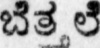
ಬೆತ್ತಲೆ
